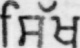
ਸਿੱਖ
